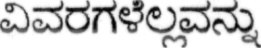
ವಿವರಗಳೆಲ್ಲವನ್ನು
